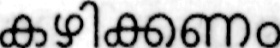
കഴിക്കണം
